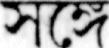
সঙ্গে
